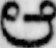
ಆ
